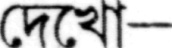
দেখো-
